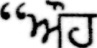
''ਔਹ
